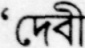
‘দেবী
